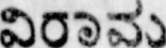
ವಿರಾಮ
